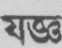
যজ্ঞ
